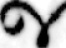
જ
